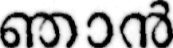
ഞാന്‍
